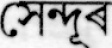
সেন্দূৰ
